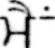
ਮੈਂ
